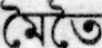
মৈতৈ
